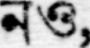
নও,
